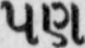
પણ
